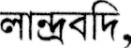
লান্দ্রবদি,
